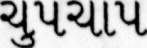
ચુપચાપ
